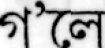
গ'লে
